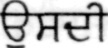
ਉਸਦੀ
